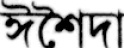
ঈশৈদো
